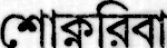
শোক্নরিবা
